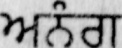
ਅਨੰਗ
